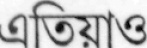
এতিয়াও
